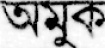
অমুক
